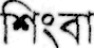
শিংবা
